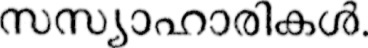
സസ്യാഹാരികള്‍.
